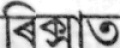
ৰিক্সাত
